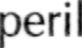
peril
